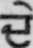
ਦੇ
